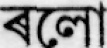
ৰলো
